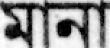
নানা
